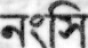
নংসি
